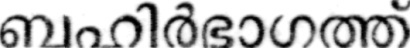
ബഹിര്‍ഭാഗത്ത്
